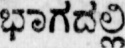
ಭಾಗದಲ್ಲಿ
